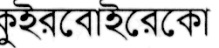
কুইরবোইরেকো
